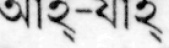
আহ্-যাহ্
